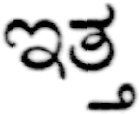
ಇತ್ತ
